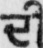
ਦੀ
